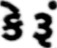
કેરૂં
